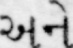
અને
